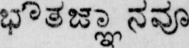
ಭೌತಜ್ಞಾನವೂ
